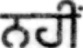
ਨਹੀਂ
